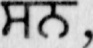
ਸਨ,
